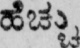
ಹೆಚ್ಚು
